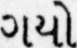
ગયો
